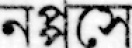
নপ্পসে
